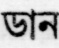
ডান
